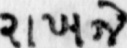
રાખજે
